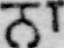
ਨਾ
